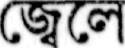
জ্বেলে
